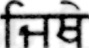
ਜਿਥੇ
